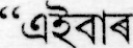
"এইবাৰ
